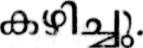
കഴിച്ചു.
